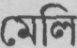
মেলি
